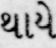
થાયે
